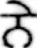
ਨੇ
